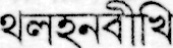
থলহনবীখি
